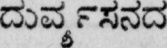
ದುರ್ವ್ಯಸನದ
